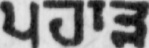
ਪਹਾੜ
